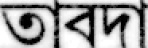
তাবদা
